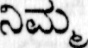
ನಿಮ್ಮ
